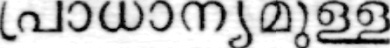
പ്രാധാന്യമുള്ള
